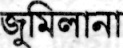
জুমিলানা
